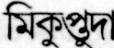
মিকুপ্তুদা
